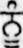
ਨੂੰ
